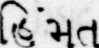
હિંમત
